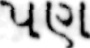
પણ
